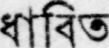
ধাবিত
